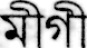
মীগী
